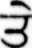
ਤੇ
